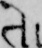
તો
